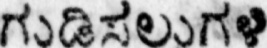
ಗುಡಿಸಲುಗಳಿ
